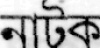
নাটক
